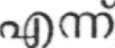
എന്ന്
